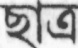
ছাত্র
